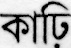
কাঢ়ি
